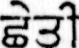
ਛੇਤੀ
